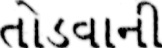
તોડવાની
